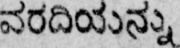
ವರದಿಯನ್ನು
